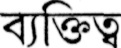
ব্যক্তিত্ব
